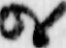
જ
